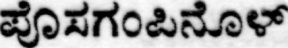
ಪೊಸಗಂಪಿನೊಳ್
